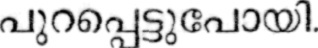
പുറപ്പെട്ടുപോയി.
